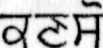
ਕਣਸੋ
